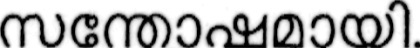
സന്തോഷമായി.
